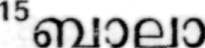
15ബാലാ
